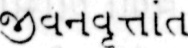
જીવનવૃત્તાંત
